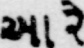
આરે
